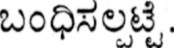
ಬಂಧಿಸಲ್ಪಟ್ಟೆ.
